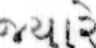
જ્યારે
